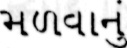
મળવાનું
